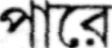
পারে
